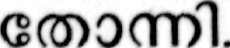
തോന്നി.
